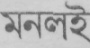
মনলই
